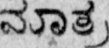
ಮಾತ್ರ
